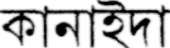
কানাইদা
